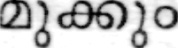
മുക്കും
